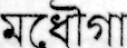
মধৌগা
